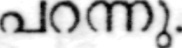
പറന്നു.
